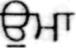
ਉਮਾ
